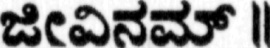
ಜೀವಿನಮ್||
